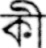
কী
